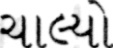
ચાલ્યો
